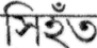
সিহঁত
